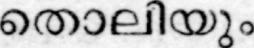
തൊലിയും
